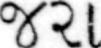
જરા
